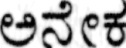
ಅನೇಕ
